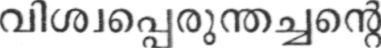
വിശ്വപ്പെരുന്തച്ചന്റെ
